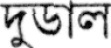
দুডাল
